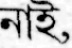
নাই,
